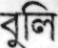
বুলি
